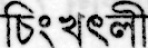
চিংখৎলী
